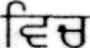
ਵਿਚ
